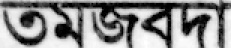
তমজবদা
